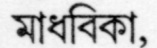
মাধবিকা,
